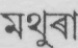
মথুৰা
